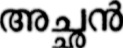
അച്ഛന്‍
